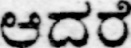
ಆದರೆ
